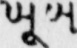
ખૂબ
